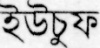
ইউচুফ
